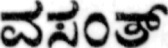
ವಸಂತ್
